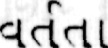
વર્તતા
